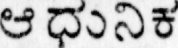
ಆಧುನಿಕ
